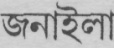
জনাইলা
